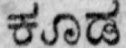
ಕೂಡ
